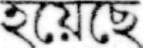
হয়েছে
